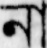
না
